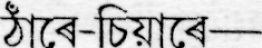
ঠাঁৰে-চিয়াৰে-
